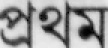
প্রথম
